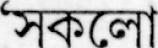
'সকলো
